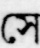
সে
